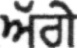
ਅੱਗੇ
